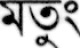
মতুং
